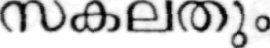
സകലതും
